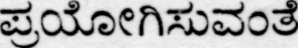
ಪ್ರಯೋಗಿಸುವಂತೆ
